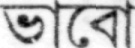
ভাবো
